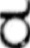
ರ
